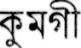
কুমগী
